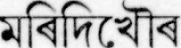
মৰিদিখৌৰ
